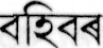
বহিবৰ
